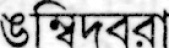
ঙম্বিদবরা
